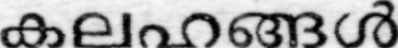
കലഹങ്ങള്‍
